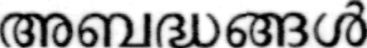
അബദ്ധങ്ങള്‍
